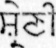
ਸ਼੍ਰੇਣੀ
